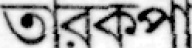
তারকপা
